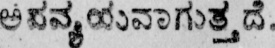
ಅಪವ್ಯಯವಾಗುತ್ತದೆ.
